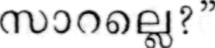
സാറല്ലെ?"
